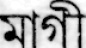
মাগী
